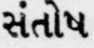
સંતોષ
